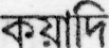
কয়াদি
